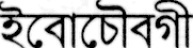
ইবোচৌবগী
